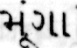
મૂંગા
